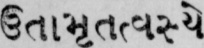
ઉંતામૃતત્વસ્યે
